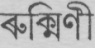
ৰুক্মিণী
